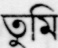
তুমি
